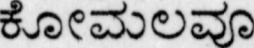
ಕೋಮಲವೂ
